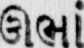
ઊભાં
